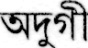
অদুগী
